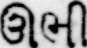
ઊભી
